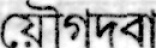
য়ৌগদবা
